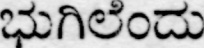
ಭುಗಿಲೆಂದು
